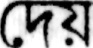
দেয়
